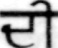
ਦੀ
